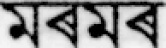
মৰমৰ
